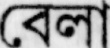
বেলা
